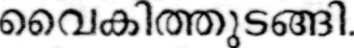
വൈകിത്തുടങ്ങി.
